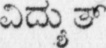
ವಿದ್ಯುತ್
